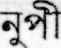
নুপী
